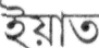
ইয়াত
